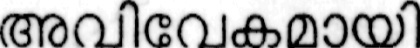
അവിവേകമായി
